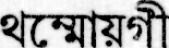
থম্মোয়গী
